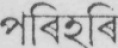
পৰিহৰি
